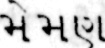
મેમણ
